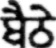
ਬੈਠੇ
